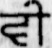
ਵੀ
